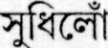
সুধিলোঁ
